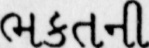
ભક્તની
